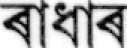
ৰাধাৰ
